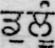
ਡੁਲੂੰ
